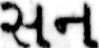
સન
